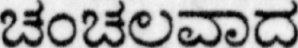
ಚಂಚಲವಾದ
